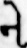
ને
